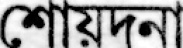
শোয়দনা
